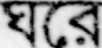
ঘরে
